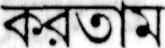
করতাম
